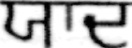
ਯਾਦ
